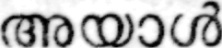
അയാള്‍
